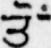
ਤੋਂ
